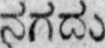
ನಗದು
